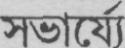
সভাৰ্য্যে
